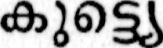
കുട്ട്യെ
